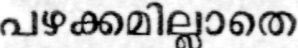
പഴക്കമില്ലാതെ
